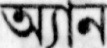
অ্যান
